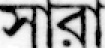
সারা
